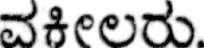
ವಕೀಲರು.
